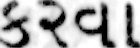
કરવા
